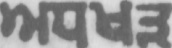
ਅਧਖੜ
